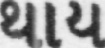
થાય
